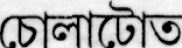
চোলাটোত
